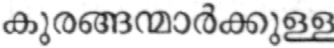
കുരങ്ങന്മാര്‍ക്കുള്ള
